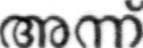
അന്ന്
